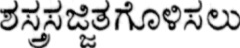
ಶಸ್ತ್ರಸಜ್ಜಿತಗೊಳಿಸಲು
